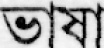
ভাষা
